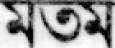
মতম
